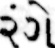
રંગે
